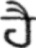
ਹੈ
